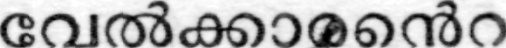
വേല്‍ക്കാരന്റെ
